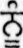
ਨੂੰ
